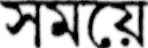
সময়ে
